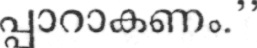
പ്പാറാകണം."
